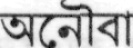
অনৌবা
